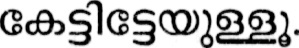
കേട്ടിട്ടേയുള്ളു.
